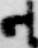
ન
